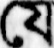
যে
